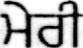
ਮੇਰੀ
